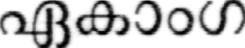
ഏകാംഗ
